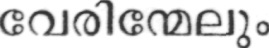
വേരിന്മേലും
